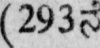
(293ನೆ
